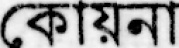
কোয়না
